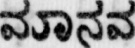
ಮಾನವ
